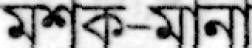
মশক-মানা
